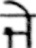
ਜੇ
